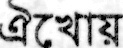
ঐখোয়
